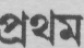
প্ৰথম
